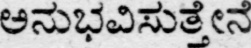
ಅನುಭವಿಸುತ್ತೇನೆ
